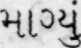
માગ્યું
